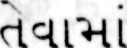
તેવામાં
